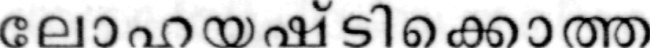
ലോഹയഷ്ടിക്കൊത്ത
